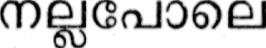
നല്ലപോലെ
